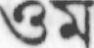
ওম
